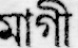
মাগী
